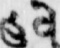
હવે
